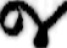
જ
